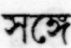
সঙ্গে
